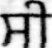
ਸੀ
